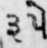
રૂપે
